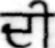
ਦੀ
